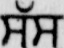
ਸੱਸ
